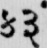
કરૂં
